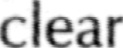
clear
